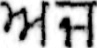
ਅਜ
